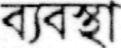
ব্যবস্থা
